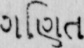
ગણિત
